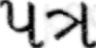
પત્ર
